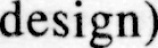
design)
